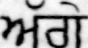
ਅੱਗੇ
